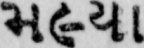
મલ્યા
